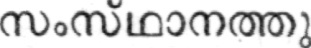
സംസ്ഥാനത്തു
